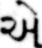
એ
